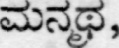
ಮನ್ಮಥ,
